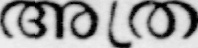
അത്ര
